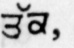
ਤੱਕ,
